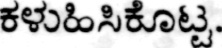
ಕಳುಹಿಸಿಕೊಟ್ಟ.
